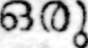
ഒരു
